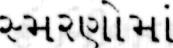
સ્મરણોમાં
